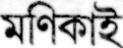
মণিকাই
